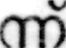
ന്ന്
